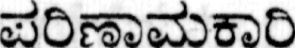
ಪರಿಣಾಮಕಾರಿ
